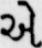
એ
